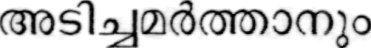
അടിച്ചമര്‍ത്താനും
